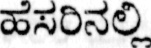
ಹೆಸರಿನಲ್ಲಿ
